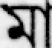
মা
